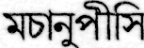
মচানুপীসি
